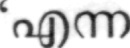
'എന്ന
